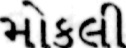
મોકલી
